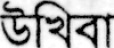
উখিবা
